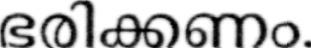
ഭരിക്കണം.
